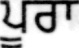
ਪੂਰਾ
